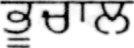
ਭੂਚਾਲ
